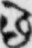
છે
